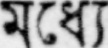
মধ্যে
